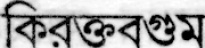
কিরক্তবগুম
